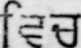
ਵਿਚ
